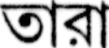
তারা
